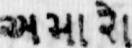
અમારો
